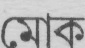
মোক
